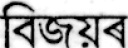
বিজয়ৰ
